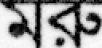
মরু
